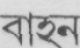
বাহন
